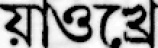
য়াওখ্রে
